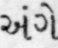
અંગે
